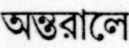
অন্তরালে
